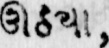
ઊઠ્યા,
